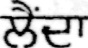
ਲੈਂਦਾ
